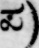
ಪ)
